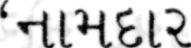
'નામદાર
